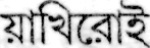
য়াখিরোই
